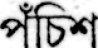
পঁচিশ
